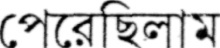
পেরেছিলাম
